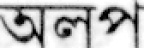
অলপ
